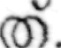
ത്.
